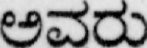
ಅವರು
